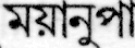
ময়ানুপা
